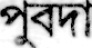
পুবদা
